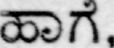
ಹಾಗೆ,
